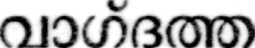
വാഗ്ദത്ത
